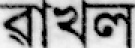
ৱাখল
